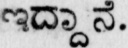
ಇದ್ದಾನೆ.
